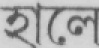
হালে
